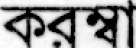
করম্বা
